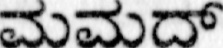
ಮಮದ್
